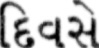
દિવસે
